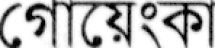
গোয়েংকা
